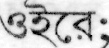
ওইরে;
